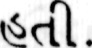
હતી.
